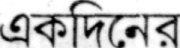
একদিনের
